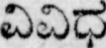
ವಿವಿಧ
